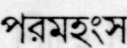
পরমহংস
